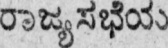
ರಾಜ್ಯಸಭೆಯ
